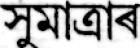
সুমাত্রাৰ
